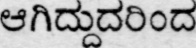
ಆಗಿದ್ದುದರಿಂದ
